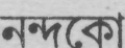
নন্দকো
